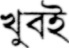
খুবই
